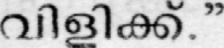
വിളിക്ക്."
